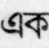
এক
